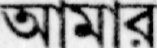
আমার
